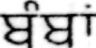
ਬੰਬਾਂ
